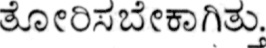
ತೋರಿಸಬೇಕಾಗಿತ್ತು.
